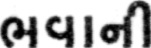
ભવાની
